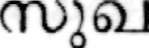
സുഖ
